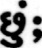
છું;
